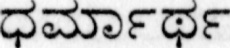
ಧರ್ಮಾರ್ಥ
